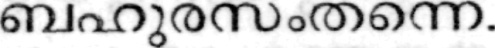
ബഹുരസംതന്നെ.
